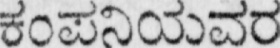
ಕಂಪನಿಯವರ
